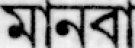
মানবা
